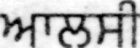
ਆਲਸੀ
